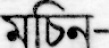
মচিন-
